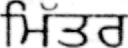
ਮਿੱਤਰ
